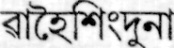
ৱাহৈশিংদুনা
